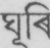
ঘূৰি
